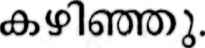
കഴിഞ്ഞു.
